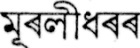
মূৰলীধৰৰ
